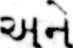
અને
